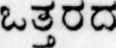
ಒತ್ತರದ
